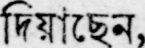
দিয়াছেন,
